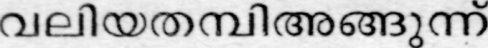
വലിയതമ്പിഅങ്ങുന്ന്
